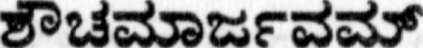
ಶೌಚಮಾರ್ಜವಮ್
